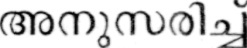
അനുസരിച്ച്
